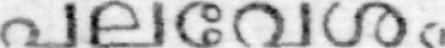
പലവേശം
